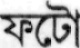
ফটো
